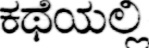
ಕಥೆಯಲ್ಲಿ
